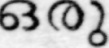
ഒരു
